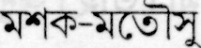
মশক-মতৌসু
